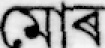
মোৰ
